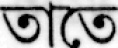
তাতে
